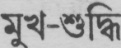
মুখ-শুদ্ধি
